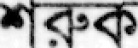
শরুক
